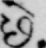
છે.
